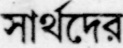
সার্থদের
